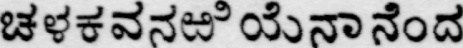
ಚಳಕವನಱಿಯೆನಾನೆಂದ
